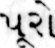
પૂરો
